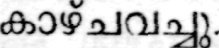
കാഴ്ചവച്ചു.
